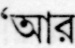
‘আর
